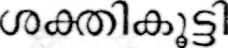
ശക്തികൂട്ടി
